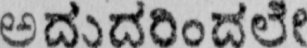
ಅದುದರಿಂದಲೇ
